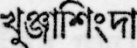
খুঞ্জাশিংদা
